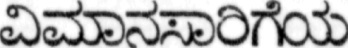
ವಿಮಾನಸಾರಿಗೆಯ
